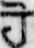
ਹੋ
